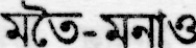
মতৈ-মনাও
